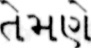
તેમણે
